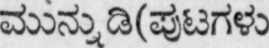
ಮುನ್ನುಡಿ(ಪುಟಗಳು
